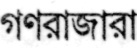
গণরাজারা
